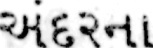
અંદરના
